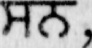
ਸਨ,
